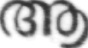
ആ
